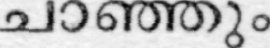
ചാഞ്ഞും
